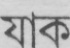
যাক
